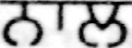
ਨਾਲ
